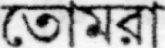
তোমরা
